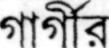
গার্গীর
